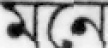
মনে
